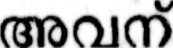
അവന്
